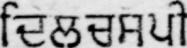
ਦਿਲਚਸਪੀ
